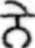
ਨੇ
